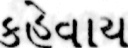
કહેવાય
